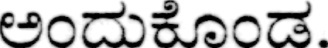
ಅಂದುಕೊಂಡ.
